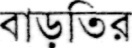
বাড়তির
